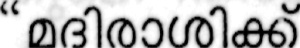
"മദിരാശിക്ക്
